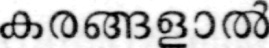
കരങ്ങളാല്‍
